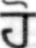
ਹੋ
